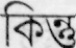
কিন্তু
